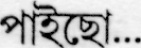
পাইছো...
